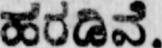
ಹರಡಿವೆ.
